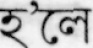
হ'লে
